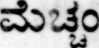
ಮೆಚ್ಚಂ
